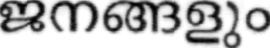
ജനങ്ങളും
